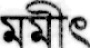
মমীৎ
